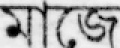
মাজে
